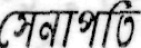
সেনাপতি
